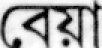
বেয়া
